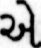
એ
